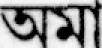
অমা
